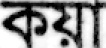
কয়া
